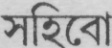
সহিবো
